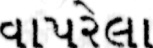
વાપરેલા
